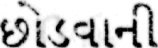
છોડવાની
